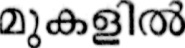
മുകളില്‍
